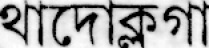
থাদোক্লগা
